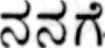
ನನಗೆ
